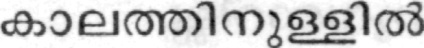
കാലത്തിനുള്ളില്‍
